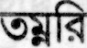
তম্নরি
